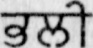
ਭਲੀ
